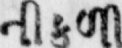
નીકળી
